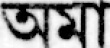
অমা
